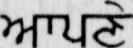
ਆਪਣੇ
